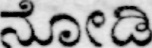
ನೋಡಿ
